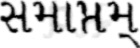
સમાપ્તમ્
